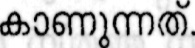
കാണുന്നത്.
